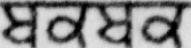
ਬਕਬਕ
